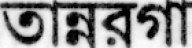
তান্নরগা
